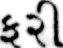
ફરી
